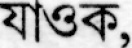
যাওক,
